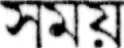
সময়
